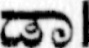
ಡಾ|
